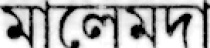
মালেমদা
